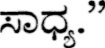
ಸಾಧ್ಯ."
